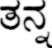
ತನ್ನ
